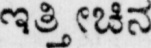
ಇತ್ತೀಚಿನ
